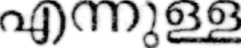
എന്നുള്ള
